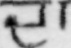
ਦਾ
